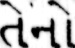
તેનો
